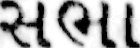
સભા
